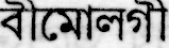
বীমোলগী
